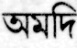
অমদি
